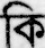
কি
